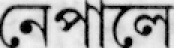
নেপালে
